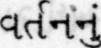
વર્તનનું
